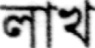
লাখ
